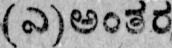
(ಎ)ಅಂತರ
